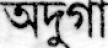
অদুগা
